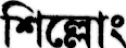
শিল্লোং
